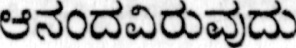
ಆನಂದವಿರುವುದು
